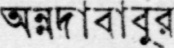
অন্নদাবাবুর
